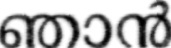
ഞാന്‍
